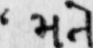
'મને
